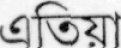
এতিয়া
